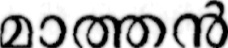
മാത്തന്‍
